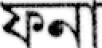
ফনা
